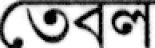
তেবল
